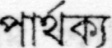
পার্থক্য
